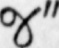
જ"
